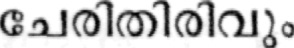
ചേരിതിരിവും
